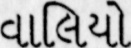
વાલિયો
